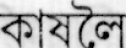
কাষলৈ
